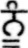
ਨੂੰ
